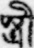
স্ত্রী
